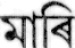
মাৰি
